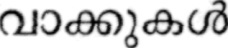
വാക്കുകള്‍
